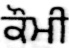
ਕੌਮੀ
